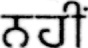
ਨਹੀਂ
